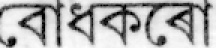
বোধকৰো
